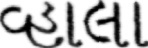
વ્હાલા
